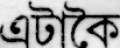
এটাকৈ
